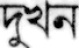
দুখন
